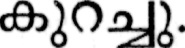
കുറച്ചു.
